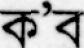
ক'ব
